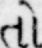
તો
